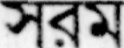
সরম
